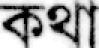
কথা
